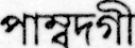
পাম্বদগী
